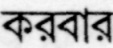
করবার
